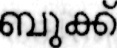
ബുക്ക്
